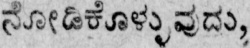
ನೋಡಿಕೊಳ್ಳುವುದು,
